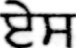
ਏਸ
